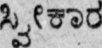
ಸ್ವೀಕಾರ
